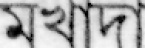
মখাদা
